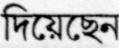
দিয়েছেন
